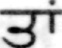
ਤਾਂ
